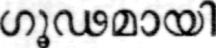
ഗൂഢമായി
